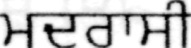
ਮਦਰਾਸੀ
